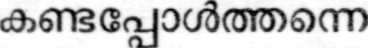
കണ്ടപ്പോള്‍ത്തന്നെ
